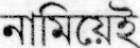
নামিয়েই
